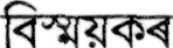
বিস্ময়কৰ
